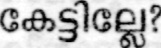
കേട്ടില്ലേ?
